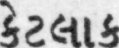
કેટલાક
